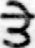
ਤੇ
